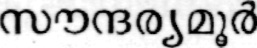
സൌന്ദര്യമൂര്‍
